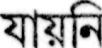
যায়নি
